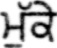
ਮੁੱਕੇ
